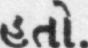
હતો.
